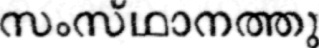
സംസ്ഥാനത്തു
